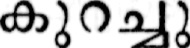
കുറച്ചു
